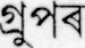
গ্ৰুপৰ
